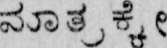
ಮಾತ್ರಕ್ಕೇ
